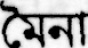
মৈনা
